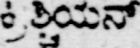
ಕ್ರಿಶ್ಚಿಯನ್
